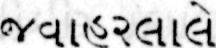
જવાહરલાલે
